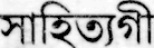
সাহিত্যগী
